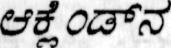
ಆಕ್ಲೆಂಡ್‌ನ
